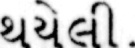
થયેલી.
